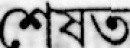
শেষত
